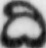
ದಿ
